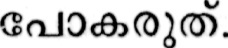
പോകരുത്.
